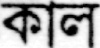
কাল
